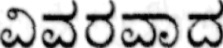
ವಿವರವಾದ
